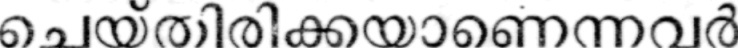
ചെയ്തിരിക്കയാണെന്നവര്‍
